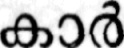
കാര്‍
